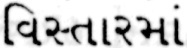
વિસ્તારમાં
